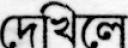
দেখিলে
